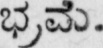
ಭ್ರಮೆ.
